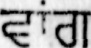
ਵਾਂਗ
